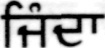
ਜਿੰਦਾ
